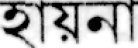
হায়না
